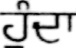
ਹੁੰਦਾ
